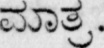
ಮಾತ್ರ.
